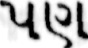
પણ
